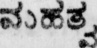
ಮಹತ್ವ
